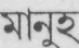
মানুহ
